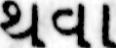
થવા
